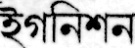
ইগনিশন
